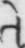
તે
